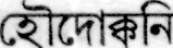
হৌদোক্কনি
